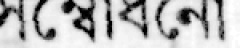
সম্বোধনো
